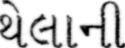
થેલાની
